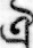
ঐ
